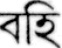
বহি
